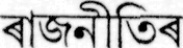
ৰাজনীতিৰ
